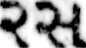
રસ
